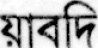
য়াবদি
